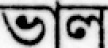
ভাল
